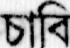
চাবি
